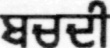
ਬਚਦੀ
